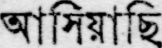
আসিয়াছি
